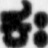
ಕಃ
